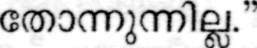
തോന്നുന്നില്ല.”
